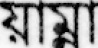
য়াম্না
